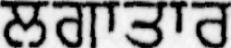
ਲਗਾਤਾਰ
